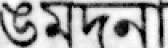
ঙমদনা
